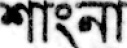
শাংনা
